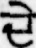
ਦੇ
